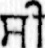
ਸੀ
